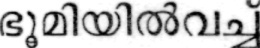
ഭൂമിയില്‍വച്ച്
